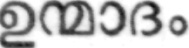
ഉന്മാദം
